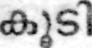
കൂടി
